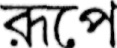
রূপে
